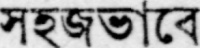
সহজভাবে
